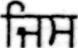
ਜਿਸ
